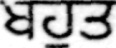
ਬਹੁਤ
